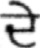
ਦੇ
